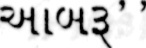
આબરૂ"
